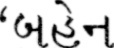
'બહેન
